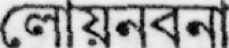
লোয়নবনা
